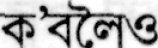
ক'বলৈও
